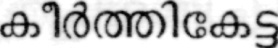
കീര്‍ത്തികേട്ട
